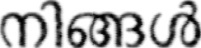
നിങ്ങള്‍
